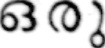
ഒരു
